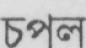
চপল
